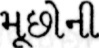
મૂછોની
